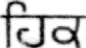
ਹਿਕ
